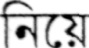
নিয়ে
